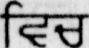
ਵਿਚ
